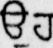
ਉਹ
